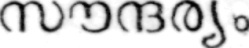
സൌന്ദര്യം
